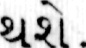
થશે.
